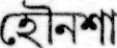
হৌনশা
